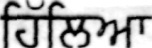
ਹਿੱਲਿਆ
